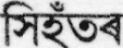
সিহঁতৰ
